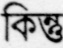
কিন্তু
